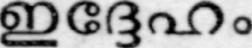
ഇദ്ദേഹം
